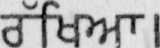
ਰੱਖਿਆ।
